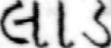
લાડ
